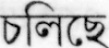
চলিছে
